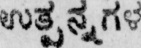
ಉತ್ಪನ್ನಗಳ
